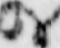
જ
